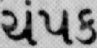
ચંપક
